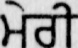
ਮੇਰੀ
